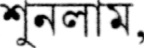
শুনলাম,
